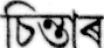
চিন্তাৰ
